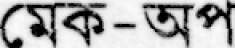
মেক-অপ
